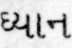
ઘ્યાન
